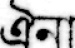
ঐনা
